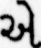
એ
